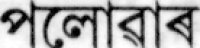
পলোৱাৰ
